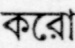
করো
